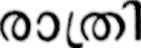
രാത്രി
